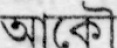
আকৌ
